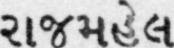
રાજમહેલ
